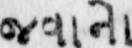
જવાનો
